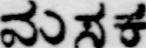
ಮಸಕ
